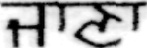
ਜਾਣਾ
